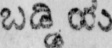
ಬಡ್ಡಿಯ
